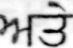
ਅਤੇ
